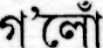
গ'লোঁ
